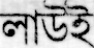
লাউই
